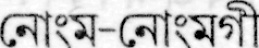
নোংম-নোংমগী
